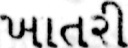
ખાતરી
